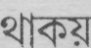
থাকয়
